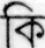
কি
